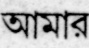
আমার
